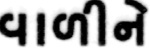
વાળીને
